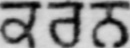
ਕਰਨ
